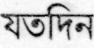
যতদিন
